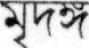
মৃদঙ্গ
